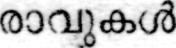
രാവുകള്‍
